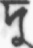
দু
